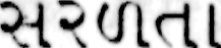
સરળતા
